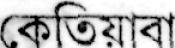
কেতিয়াবা
